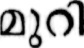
മുറി
